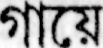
গায়ে
